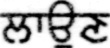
ਲਾਉਣ
